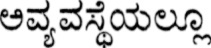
ಅವ್ಯವಸ್ಥೆಯಲ್ಲೂ
